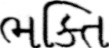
ભક્તિ
